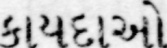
કાયદાઓ
